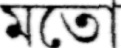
মতো
